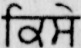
ਕਿਸੇ
